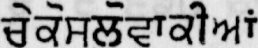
ਚੇਕੋਸਲੋਵਾਕੀਆਂ
